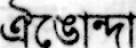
ঐঙোন্দা
